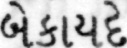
બેકાયદે
